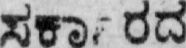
ಸರ್ಕಾರದ
